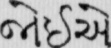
જોઈએ
